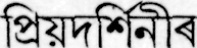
প্রিয়দৰ্শিনীৰ
